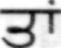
ਤਾਂ
